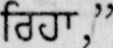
ਰਿਹਾ,''
